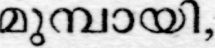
മുമ്പായി,
